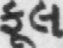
ફૂલ
